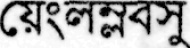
য়েংলম্লবসু
